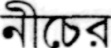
নীচের
